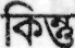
কিন্তু
